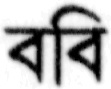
ববি
